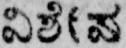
ವಿಶೇಷ
